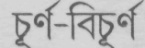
চূৰ্ণ-বিচূৰ্ণ
